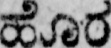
ಹೊರ
